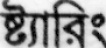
ষ্ট্যারিং
